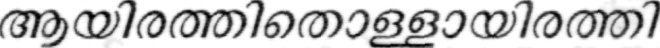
ആയിരത്തിതൊള്ളായിരത്തി
